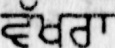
ਵੱਖਰਾ
